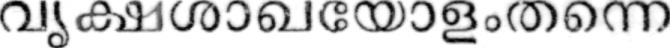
വൃക്ഷശാഖയോളംതന്നെ
